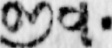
જીવ-
